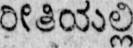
ರೀತಿಯಲ್ಲಿ
